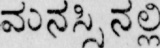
ಮನಸ್ಸಿನಲ್ಲಿ
